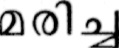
മരിച്ച
